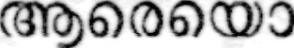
ആരെയൊ
